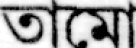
তামো
